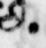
છ.
